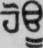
ਹੋਊ
